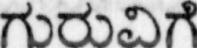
ಗುರುವಿಗೆ
